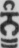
ਨੂੰ
